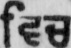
ਵਿਚ
